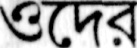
ওদের
